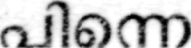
പിന്നെ
